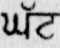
ਘੱਟ
